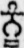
ਨੂੰ
